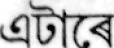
এটাৰে
